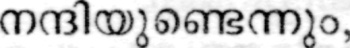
നന്ദിയുണ്ടെന്നും,
